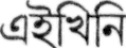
এইখিনি
